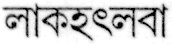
লাকহৎলবা
